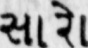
સારો
